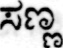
ಸಣ್ಣ
